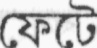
ফেটে
